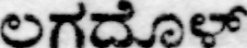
ಲಗದೊಳ್
